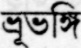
ভ্রূভঙ্গি
